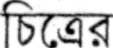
চিত্রের
